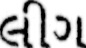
લીગ
